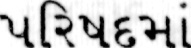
પરિષદમાં
